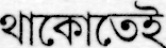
থাকোতেই
